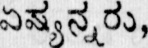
ಏಷ್ಯನ್ನರು,
